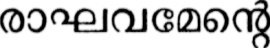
രാഘവമേന്റെ
